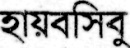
হায়বসিবু
